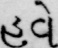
હવે
